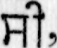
ਸੀ,
